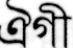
ঐগী
